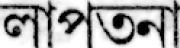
লাপতনা
